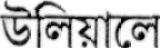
উলিয়ালে
